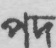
পদ
